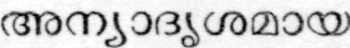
അന്യാദൃശമായ
